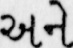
અને
